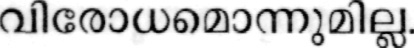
വിരോധമൊന്നുമില്ല.
